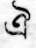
ঐ
